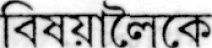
বিষয়ালৈকে
